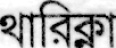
থারিক্না
